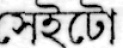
সেইটো
